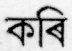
কৰি
